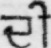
ਦੀ
